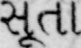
સૂતા
